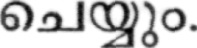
ചെയ്യും.
